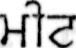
ਮੀਟ
